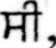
ਸੀ,
